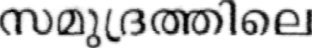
സമുദ്രത്തിലെ
